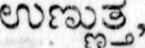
ಉಣ್ಣುತ್ತ,
